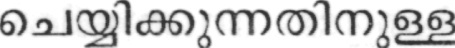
ചെയ്യിക്കുന്നതിനുള്ള
